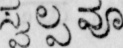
ಸ್ವಲ್ಪವೂ
